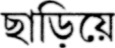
ছাড়িয়ে
